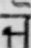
ਜੋ
